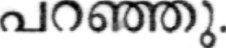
പറഞ്ഞു.
